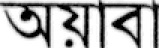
অয়াবা
